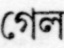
গেল
